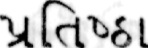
પ્રતિષ્ઠા
